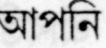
আপনি
